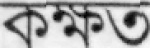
কক্ষত
